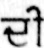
ਦੀ
